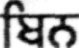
ਬਿਨ
